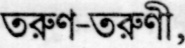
তরুণ-তরুণী,
